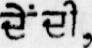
ਦੇਂਦੀ,
